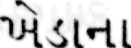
ખેડાના
